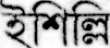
ইশিল্লি
